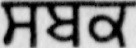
ਸਬਕ
